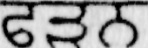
ਫੜਨ
